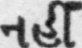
નહીં
